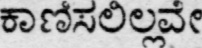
ಕಾಣಿಸಲಿಲ್ಲವೇ
